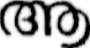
ആ
